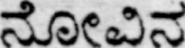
ನೋವಿನ
